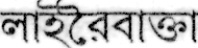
লাইরৈবাক্তা
